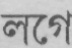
লগে
